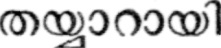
തയ്യാറായി
